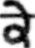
ਕੇ
